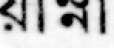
য়াম্না
